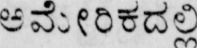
ಅಮೇರಿಕದಲ್ಲಿ
